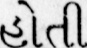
હોતી
